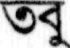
তবু
